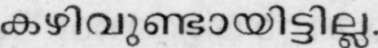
കഴിവുണ്ടായിട്ടില്ല.
